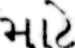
માટે
